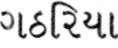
ગઠરિયા
